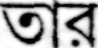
তার
